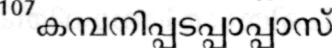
107കമ്പനിപ്പടപ്പാപ്പാസ്
